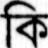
কি
